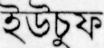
ইউচুফ
